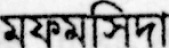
মফমসিদা
